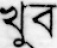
খুব
